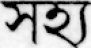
সহ্য
